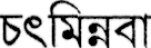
চৎমিন্নবা
